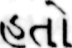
હતો
